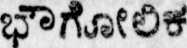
ಭೌಗೋಲಿಕ
